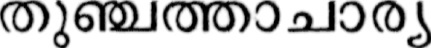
തുഞ്ചത്താചാര്യ
